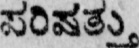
ಪರಿಷತ್ತು
